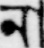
না
